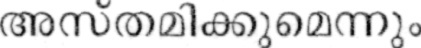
അസ്തമിക്കുമെന്നും
